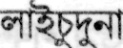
লাইচুদুনা
